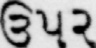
ઉપર
